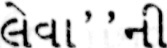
લેવા"ની
